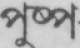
পুষ্প
